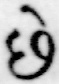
છે
